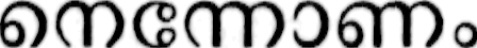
നെന്നോണം
